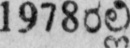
1978ರಲ್ಲಿ
